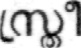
സ്ത്രീ
